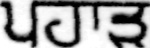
ਪਹਾੜ
